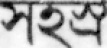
সহস্র
